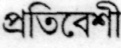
প্রতিবেশী
